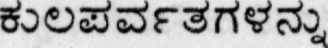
ಕುಲಪರ್ವತಗಳನ್ನು
